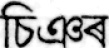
চিঞৰ
